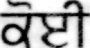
ਕੋਈ
